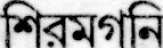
শিরমগনি
